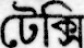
টেক্সি
